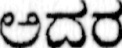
ಅದರ
